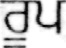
ਰੂਪ
